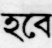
হবে
